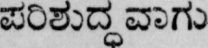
ಪರಿಶುದ್ದವಾಗು
